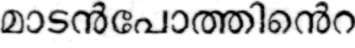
മാടന്‍പോത്തിന്റെ
